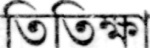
তিতিক্ষা
